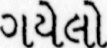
ગયેલો
